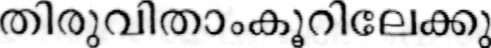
തിരുവിതാംകൂറിലേക്കു
